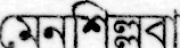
মেনশিল্লবা
